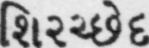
શિરચ્છેદ
